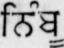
ਨਿੰਬੂ
